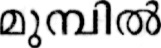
മുമ്പില്‍
